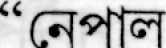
"নেপাল
